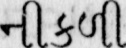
નીકળી
